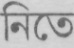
নিতে
